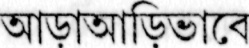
আড়াআড়িভাবে
